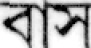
বাস
